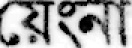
য়েংনা
